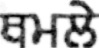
ਥਮਲੇ
